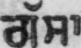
ਗੱਸਾ
